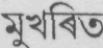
মুখৰিত
